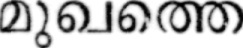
മുഖത്തെ
